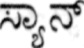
ಸ್ಯಾನ್
